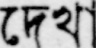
দেখা
